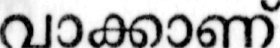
വാക്കാണ്
